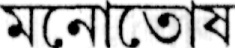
মনোতোষ
